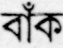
বাঁক
